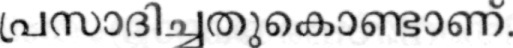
പ്രസാദിച്ചതുകൊണ്ടാണ്.
